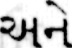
અને
